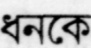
ধনকে
